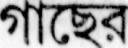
গাছের
